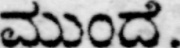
ಮುಂದೆ.
